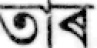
তাৰ
